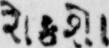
રોકશો
